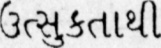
ઉત્સુકતાથી
